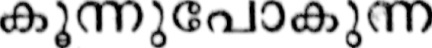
കൂന്നുപോകുന്ന
